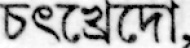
চৎখ্রেদো,
